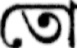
তো
